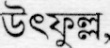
উৎফুল্ল,
